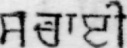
ਸਚਾਈ
